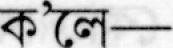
ক'লে-
